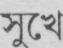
সুখে
